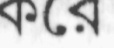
করে
